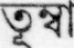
তু্ম্বা
